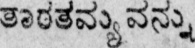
ತಾರತಮ್ಯವನ್ನು
